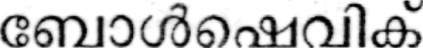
ബോള്‍ഷെവിക്
